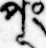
পূং
